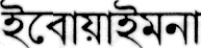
ইবোয়াইমা
